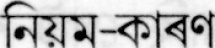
নিয়ম-কাৰণ
